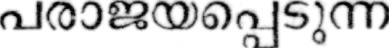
പരാജയപ്പെടുന്ന
